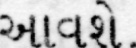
આવશે.
